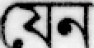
যেন
